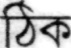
ঠিক
